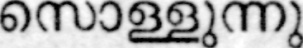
സൊള്ളുന്നു
